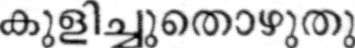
കുളിച്ചുതൊഴുതു
